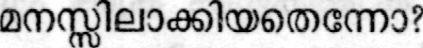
മനസ്സിലാക്കിയതെന്നോ?
